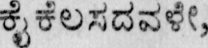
ಕೈಕೆಲಸದವಳೇ,
